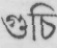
গুচি
